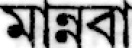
মান্নবা
